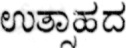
ಉತ್ಸಾಹದ
